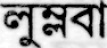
লুম্লবা
